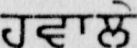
ਹਵਾਲੇ
